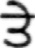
ਤੇ
